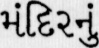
મંદિરનું
